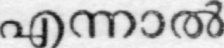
എന്നാല്‍
